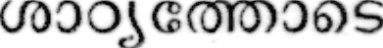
ശാഠ്യത്തോടെ
